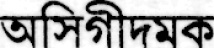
অসিগীদমক
